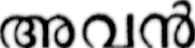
അവന്‍
